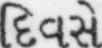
દિવસે
